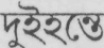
দুইহন্তে
